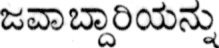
ಜವಾಬ್ದಾರಿಯನ್ನು
